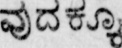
ವುದಕ್ಕೂ
